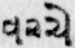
વચ્ચે
